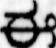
ಈ
